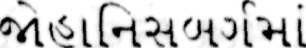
જોહાનિસબર્ગમાં
